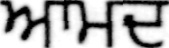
ਆਮਦ
